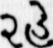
રહે
